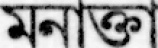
মনাক্তা
